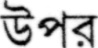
উপর
